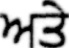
ਅਤੇ
